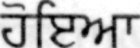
ਹੋਇਆ
